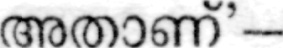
അതാണ്’-
